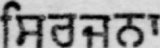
ਸਿਰਜਨਾ
